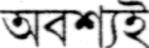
অবশ্যই
